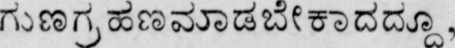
ಗುಣಗ್ರಹಣಮಾಡಬೇಕಾದದ್ದೂ,
